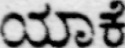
ಯಾಕೆ
